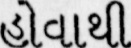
હોવાથી
